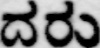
ದರು
